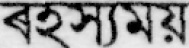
ৰহস্যময়
